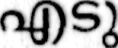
എടു
